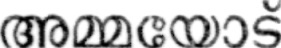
അമ്മയോട്
